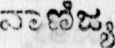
ವಾಣಿಜ್ಯ
